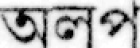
অলপ
